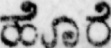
ಹೊರೆ
